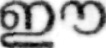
ഈ
